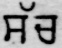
ਸੱਚ
